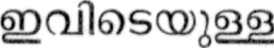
ഇവിടെയുള്ള
